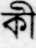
কী
